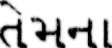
તેમના
